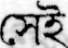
সেই
